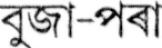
বুজা-পৰা
